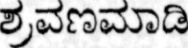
ಶ್ರವಣಮಾಡಿ
